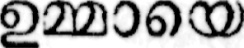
ഉമ്മായെ
